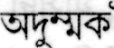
অদুম্মক
